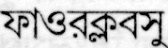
ফাওরক্লবসু
